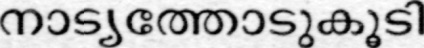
നാട്യത്തോടുകൂടി
